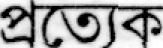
প্রত্যেক
